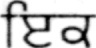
ਇਕ
